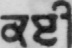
ਕਈ
